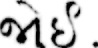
જોઈ.
